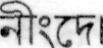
নীংদে।
